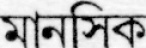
মানসিক
